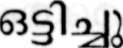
ഒട്ടിച്ചു
